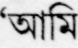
‘আমি
